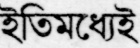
ইতিমধ্যেই
